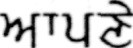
ਆਪਣੇ
